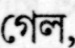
গেল,
